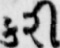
કરી
